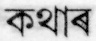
কথাৰ
